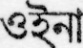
ওইনা
